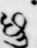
છું
